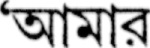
‘আমার
